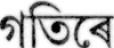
গতিৰে
